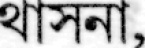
থাসনা,
